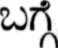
ಬಗ್ಗೆ
